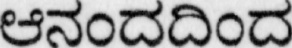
ಆನಂದದಿಂದ
